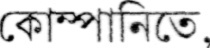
কোম্পানিতে,
